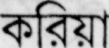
করিয়া
